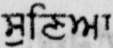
ਸੁਣਿਆ
